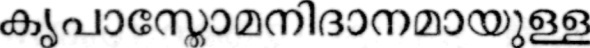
കൃപാസ്തോമനിദാനമായുള്ള
